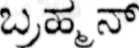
ಬ್ರಹ್ಮನ್
